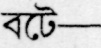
বটে–
